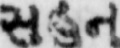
સહન
